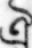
ঐ
